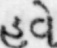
હવે
